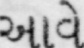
આવે
